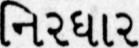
નિરધાર
